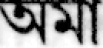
অমা
